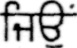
ਜਿਉਂ
